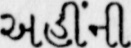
અહીંની
